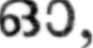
ഓ,
